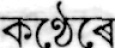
কণ্ঠেৰে
